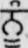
ਨੂੰ
